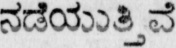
ನಡೆಯುತ್ತಿವೆ
